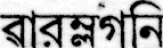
ৱারম্লগনি
